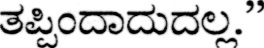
ತಪ್ಪಿಂದಾದುದಲ್ಲ."
